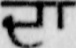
ਦਾ
